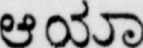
ಆಯಾ
